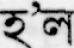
হ'ল
